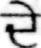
ਦੇ
